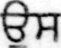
ਉਸ
